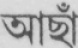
আছাঁ
